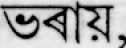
ভৰায়,
